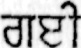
ਗਈ
